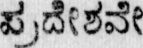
ಪ್ರದೇಶವೇ
